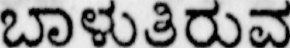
ಬಾಳುತಿರುವ
